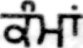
ਕੰਮਾਂ
